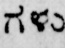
ಗಳು
